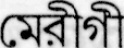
মেরীগী
